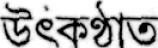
উৎকণ্ঠাত
